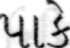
પાકે
